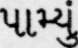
પામ્યું
